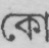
কো
